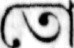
তো
